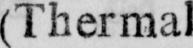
(Thermal
